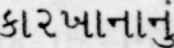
કારખાનાનુ
